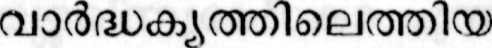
വാര്‍ദ്ധക്യത്തിലെത്തിയ
